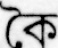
কৈ
